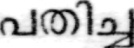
പതിച്ച
